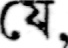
যে,
